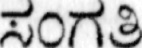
ಸಂಗತಿ
